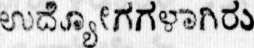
ಉದ್ಯೋಗಗಳಾಗಿರು
